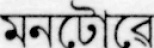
মনটোৱে
